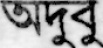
অদুবু
